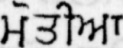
ਮੋਤੀਆ
